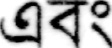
এবং
